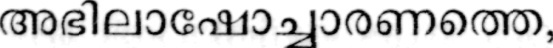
അഭിലാഷോച്ചാരണത്തെ,
